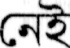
নেই
